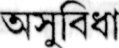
অসুবিধা
